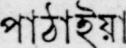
পাঠাইয়া
